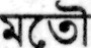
মতৌ
